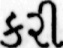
કરી
